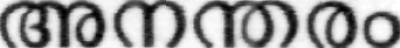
അനന്തരം
